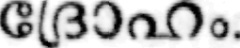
ദ്രോഹം.
